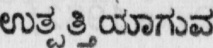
ಉತ್ಪತ್ತಿಯಾಗುವ
